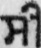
ਸੀ
